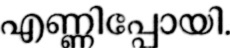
എണ്ണിപ്പോയി.
